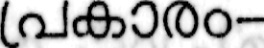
പ്രകാരം-
